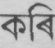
কৰি
